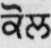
ਕੋਲ
